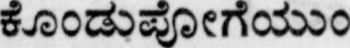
ಕೊಂಡುಪೋಗೆಯುಂ
